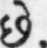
છે.
